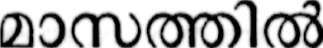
മാസത്തില്‍
